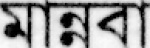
মান্নবা
